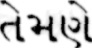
તેમણે
